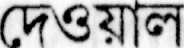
দেওয়াল
